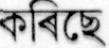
কৰিছে
